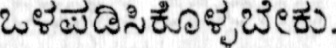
ಒಳಪಡಿಸಿಕೊಳ್ಳಬೇಕು.
